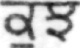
ਕੁਝ
